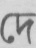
দে
